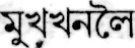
মুখখনলৈ
